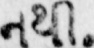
નથી.
